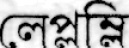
লেপ্লম্মি
